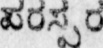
ಪರಸ್ಪರ
